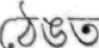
ঠেঙত
